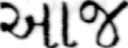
આજ
